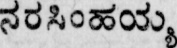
ನರಸಿಂಹಯ್ಯ
